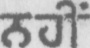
ਨਹੀਂ
